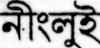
নীংলুই
